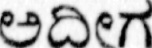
ಅದೀಗ
